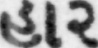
હાર
